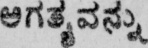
ಅಗತ್ಯವನ್ನು
